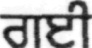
ਗਈ
